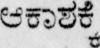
ಆಕಾಶಕ್ಕೆ
